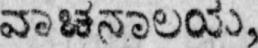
ವಾಚನಾಲಯ,
